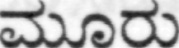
ಮೂರು
